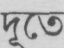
দূতে
